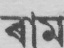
ৰাম
